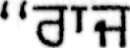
''ਰਾਜ
